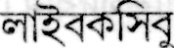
লাইবকসিবু
